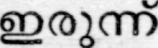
ഇരുന്ന്
